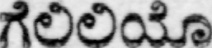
ಗೆಲಿಲಿಯೊ
